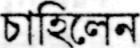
চাহিলেন
